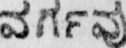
ವರ್ಗವು
